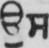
ਉਸ
